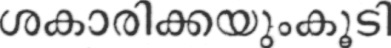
ശകാരിക്കയുംകൂടി
